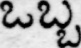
ಒಬ್ಬ
